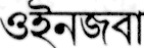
ওইনজবা
